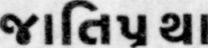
જાતિપ્રથા
